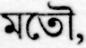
মতৌ,
